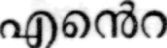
എന്റെ
